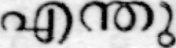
എന്തു
